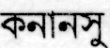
কনানসু
